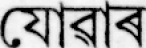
যোৱাৰ
